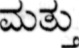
ಮತ್ತು
